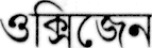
ওক্সিজেন
